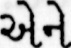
એને
